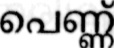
പെണ്ണ്
